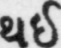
થઇ
